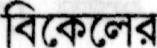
বিকেলের
